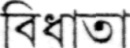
বিধাতা
